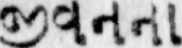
જીવનના
